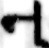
ન
